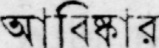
আবিষ্কার
